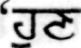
'ਹੁਣ
